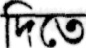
দিতে
